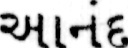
આનંદ
